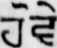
ਹੋਵੇ
